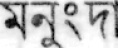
মনুংদা
